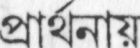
প্রার্থনায়
